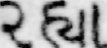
રહ્યા
